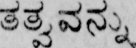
ತತ್ವವನ್ನು
